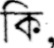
কি,
